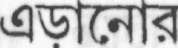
এড়ানোর
